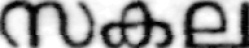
സകല
